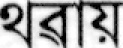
থৱায়
